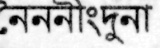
নৈননীংদুনা
